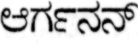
ಆರ್ಗನನ್
